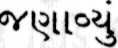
જણાવ્યું
